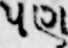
પણ
